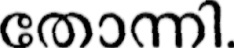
തോന്നി.
